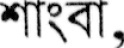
শাংবা,
